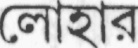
লোহার
